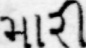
મારી
